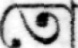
তো
